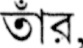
তাঁর,
